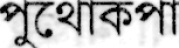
পুথোকপা
